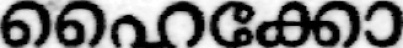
ഹൈക്കോ
